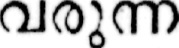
വരുന്ന
